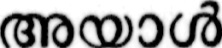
അയാള്‍
